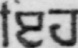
ਇਹ
